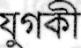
যুগকী
